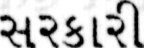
સરકારી
